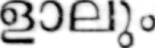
ളാലും
